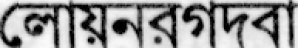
লোয়নরগদবা
